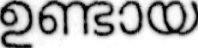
ഉണ്ടായ
